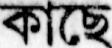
কাছে
